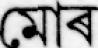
মোৰ
